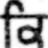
ਕਿ
